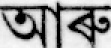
আৰু
